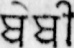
ਬੇਬੀ
